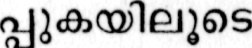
പ്പുകയിലൂടെ
